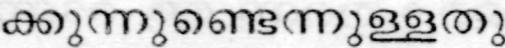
ക്കുന്നുണ്ടെന്നുള്ളതു
